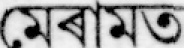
মেৰামত
